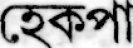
হেকপা
